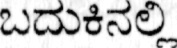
ಬದುಕಿನಲ್ಲಿ
